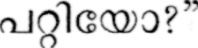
പറ്റിയോ?"
